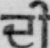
ਦੀ
